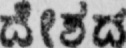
ದೇಶದ
